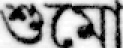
শুমো
